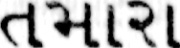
તમારા
